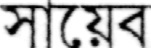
সায়েব
